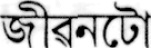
জীৱনটো
